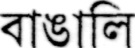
বাঙালি
